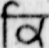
ਕਿ
